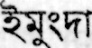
ইমুংদা
